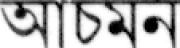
আচমন
